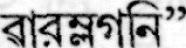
ৱারম্লগনি”
